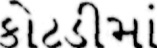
કોટડીમાં
